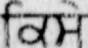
ਕਿਸੇ
